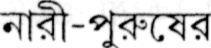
নারী-পুরুষের
